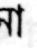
না
